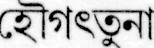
হৌগৎতুনা
